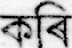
কৰি
